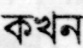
কখন
